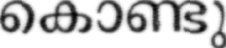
കൊണ്ടു
